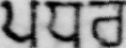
ਪਧਰ
